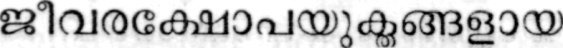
ജീവരക്ഷോപയുക്തങ്ങളായ
